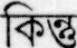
কিন্তু
